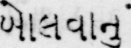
બોલવાનું
